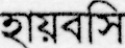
হায়বসি
